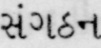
સંગઠન
